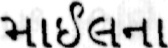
માઈલના
